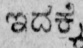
ಇದಕ್ಕೆ
